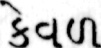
કેવળ
